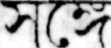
সঙ্গে
